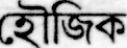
হৌজিক
